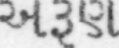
અરૂણ
